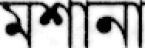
মশানা
